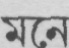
মনে
